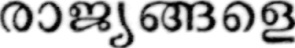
രാജ്യങ്ങളെ
